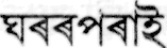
ঘৰৰপৰাই
